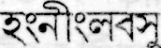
হংনীংলবসু
